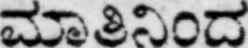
ಮಾತಿನಿಂದ
